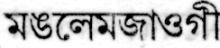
মঙলেমজাওগী
